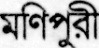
মণিপুরী
